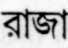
রাজা
